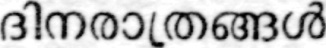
ദിനരാത്രങ്ങള്‍
